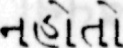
નહોતો
